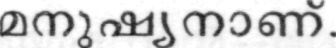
മനുഷ്യനാണ്.
